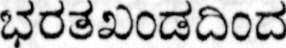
ಭರತಖಂಡದಿಂದ
